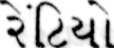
રેંટિયો
